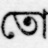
তো
